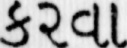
કરવા
